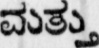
ಮತ್ತು
